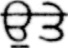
ਉਤੇ
